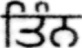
ਤਿੰਨ
